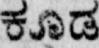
ಕೂಡ
